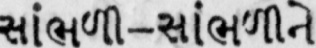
સાંભળીને
